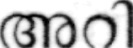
അറി
